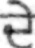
ਦੇ
